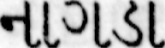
નાગડા
